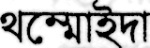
থম্মোইদা
